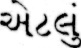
એટલું
